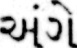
અંગે
